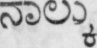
ನಾಲ್ಕು
